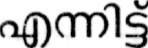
എന്നിട്ട്
